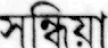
সন্ধিয়া
